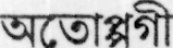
অতোপ্পগী
